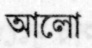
আলো
